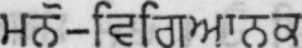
ਮਨੋ-ਵਿਗਿਆਨਕ
